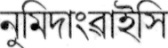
নুমিদাংৱাইসি
